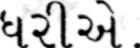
ધરીએ.
